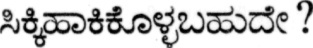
ಸಿಕ್ಕಿಹಾಕಿಕೊಳ್ಳಬಹುದೇ?
